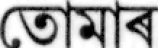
তোমাৰ
